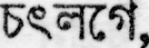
চৎলগে,
